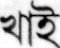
খাই
